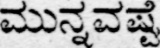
ಮುನ್ನವಷ್ಟೆ
